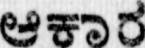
ಆಕಾರ
